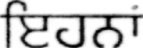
ਇਹਨਾਂ
